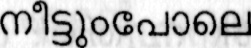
നീട്ടുംപോലെ
